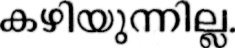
കഴിയുന്നില്ല.
